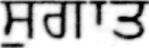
ਸੁਗਾਤ
